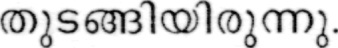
തുടങ്ങിയിരുന്നു.
